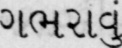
ગભરાવું
